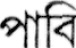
পাবি
